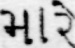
મારે
